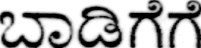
ಬಾಡಿಗೆಗೆ
